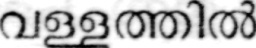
വള്ളത്തില്‍
